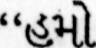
"હમો
